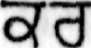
ਕਰ
